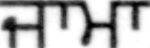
ਜਾਮਾ
